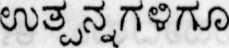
ಉತ್ಪನ್ನಗಳಿಗೂ
